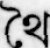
থৈ
